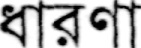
ধারণা
